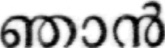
ഞാന്‍
